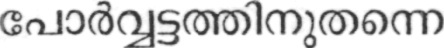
പോര്‍വ്വട്ടത്തിനുതന്നെ
